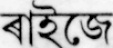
ৰাইজে
